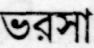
ভরসা
